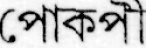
পোকপী
